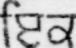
ਇਕ
